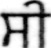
ਸੀ
